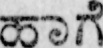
ಹಾಗೆ
